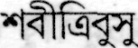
শাবীত্রিবুসু
